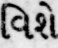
વિશે
